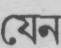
যেন
